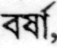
বর্ষা,
